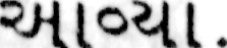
આવ્યા.
